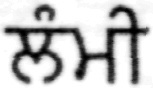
ਲੰਮੀ
